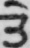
ਤੇ
